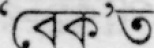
'বেক'ত
